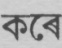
কৰে
